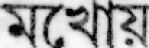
মখোয়
